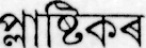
প্লাষ্টিকৰ
